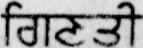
ਗਿਣਤੀ
